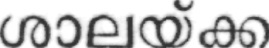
ശാലയ്ക്ക
